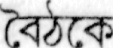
বৈঠকে
